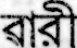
ৱারী
